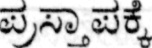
ಪ್ರಸ್ತಾಪಕ್ಕೆ
